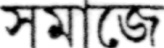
সমাজে
